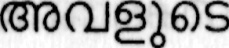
അവളുടെ
